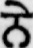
ਨੇ
